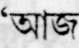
‘আজ
